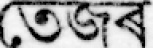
তেজৰ
